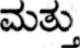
ಮತ್ತು
